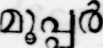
മൂപ്പര്‍
